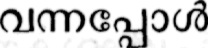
വന്നപ്പോള്‍
